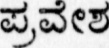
ಪ್ರವೇಶ
